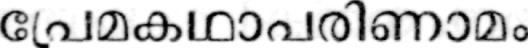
പ്രേമകഥാപരിണാമം
